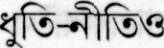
ধুতি-নীতিও
